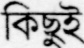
কিছুই
